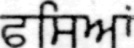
ਫਸਿਆਂ
